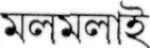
মলমলাই
